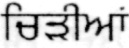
ਚਿੜੀਆਂ
